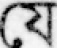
যে
